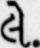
લે."
